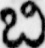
ಬಿ
